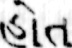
હોત
